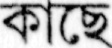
কাছে
